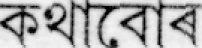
কথাবোৰ
